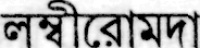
লম্বীরোমদা
